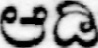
ಆಡಿ
